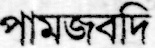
পামজবদি
